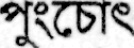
পুংচোৎ
